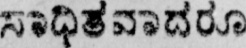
ಸಾಧಿತವಾದರೂ
